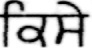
ਕਿਸੇ
